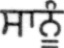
ਸਾਨੂੰ
